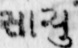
સાચું
